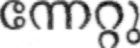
ന്നേറ്റു
